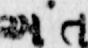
અંત
